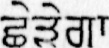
ਛੇੜੇਗਾ
